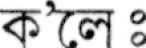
ক'লেঃ
